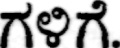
ಗಳಿಗೆ.
